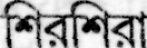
শিরশিরা
